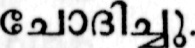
ചോദിച്ചു.
